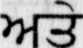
ਅਤੇ
